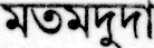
মতমদুদা
